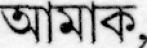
আমাক,
